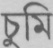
চুমি
